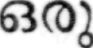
ഒരു
